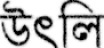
উৎলি
